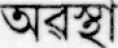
অৱস্হা
